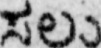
ಸಲು
